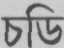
চড়ি
